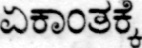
ಏಕಾಂತಕ್ಕೆ
